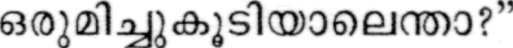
ഒരുമിച്ചുകൂടിയാലെന്താ?”
